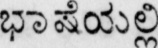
ಭಾಷೆಯಲ್ಲಿ
